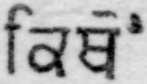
ਕਿਥੋਂ
